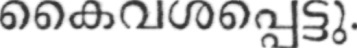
കൈവശപ്പെട്ടു.
